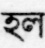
হল
